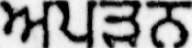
ਅਪੜਨ
